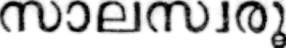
സാലസ്വരൂ
